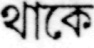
থাকে
